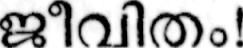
ജീവിതം!
